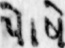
પોષે
